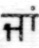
ਜਾਂ
